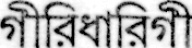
গীরিধারিগী
